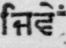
ਜਿਵੇਂ
